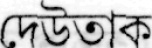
দেউতাক
